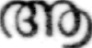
ആ
